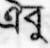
ঐবু
